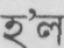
হ'ল
